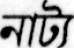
নাট্য
